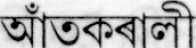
আঁতকৰালী
